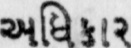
અધિકાર
